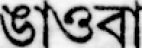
ঙাওবা
